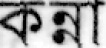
কন্না
